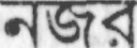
নজর
